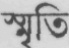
স্মৃতি
